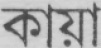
কায়া
